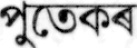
পুতেকৰ
